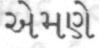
એમણે
